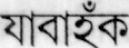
যাবাহঁক
